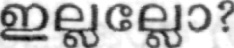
ഇല്ലല്ലോ?
